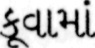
કૂવામાં
